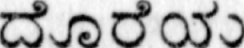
ದೊರೆಯ
